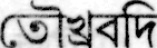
তৌখ্রবদি
